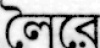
লৈরে
